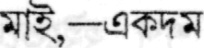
মাই,—একদম
